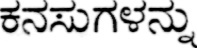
ಕನಸುಗಳನ್ನು
